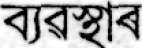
ব্যৱস্থাৰ
